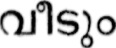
വീടും
